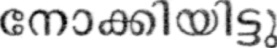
നോക്കിയിട്ടു
